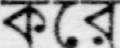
করে
